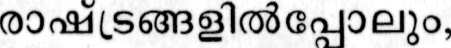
രാഷ്ട്രങ്ങളില്‍പ്പോലും,
